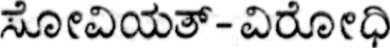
ಸೋವಿಯತ್-ವಿರೋಧಿ
